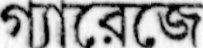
গ্যারেজে
